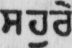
ਸਹੁਰੇ
